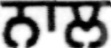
ਨਾਲ
